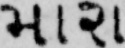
મારા
